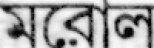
মরোল
